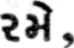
રમે,
